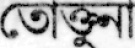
তোক্তুনা
